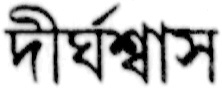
দীর্ঘশ্বাস
